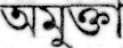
অমুক্তা
